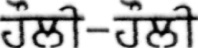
ਹੌਲੀ-ਹੌਲੀ
